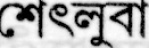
শেৎলুবা
